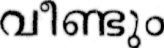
വീണ്ടും
